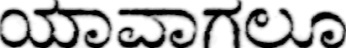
ಯಾವಾಗಲೂ
